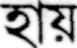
হায়
